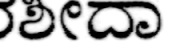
ರಶೀದಾ
